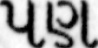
પણ
